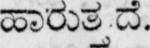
ಹಾರುತ್ತದೆ.
